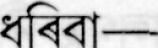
ধৰিবা-
